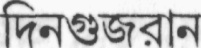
দিনগুজরান
